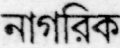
নাগরিক
